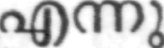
എന്നു
